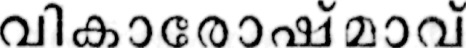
വികാരോഷ്മാവ്
